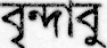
বৃন্দাবু
